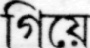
গিয়ে
